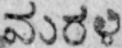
ಮರಳಿ
